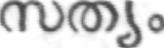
സത്യം
